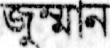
জুম্মান
